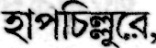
হাপচিল্লুরে,
